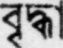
বৃদ্ধা
